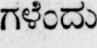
ಗಳೆಂದು
